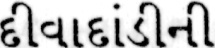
દીવાદાંડીની
